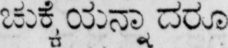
ಚುಕ್ಕೆಯನ್ನಾದರೂ
